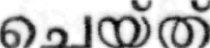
ചെയ്ത്
